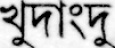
খুদাংদু
